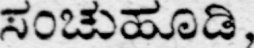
ಸಂಚುಹೂಡಿ,
